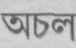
অচল
